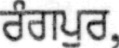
ਰੰਗਪੁਰ,
